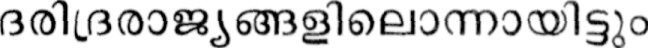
ദരിദ്രരാജ്യങ്ങളിലൊന്നായിട്ടും
